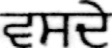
ਵਸਦੇ
